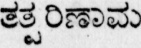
ತತ್ಪರಿಣಾಮ
